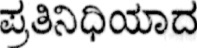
ಪ್ರತಿನಿಧಿಯಾದ
